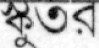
স্কুতর
